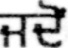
ਜਦੋਂ
